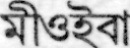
মীওইবা
